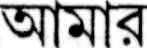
আমার
